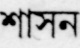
শাসন
